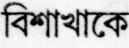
বিশাখাকে
